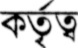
কর্তৃত্ব
